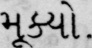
મૂક્યો.
